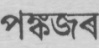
পঙ্কজৰ
